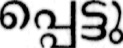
പ്പെട്ടു
